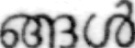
ങ്ങള്‍
